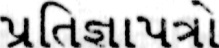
પ્રતિજ્ઞાપત્રો
